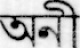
অনী
